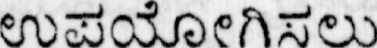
ಉಪಯೋಗಿಸಲು
